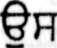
ਉਸ
